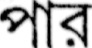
পার
